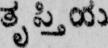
ತೃಪ್ತಿಯ
